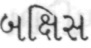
બક્ષિસ
